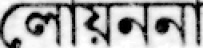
লোয়ননা
